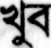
খুব
